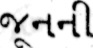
જૂનની
